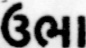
ઉભા
